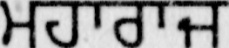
ਮਹਾਰਾਜ
